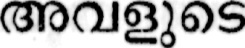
അവളുടെ
